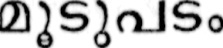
മൂടുപടം
